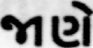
જાણે
